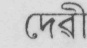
দেৱী
